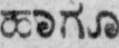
ಹಾಗೂ
